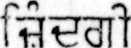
ਜ਼ਿੰਦਗੀ
